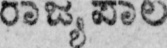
ರಾಜ್ಯಪಾಲ
